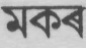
মকৰ
